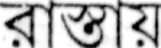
রাস্তায়
